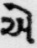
એ
